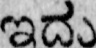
ಇದು
